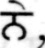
ਨੇ,
